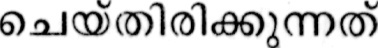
ചെയ്തിരിക്കുന്നത്
